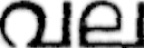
വല
